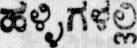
ಹಳ್ಳಿಗಳಲ್ಲಿ
